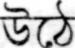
উঠে
